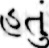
હતું
